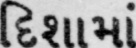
દિશામાં
